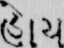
હોય
